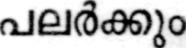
പലര്‍ക്കും
